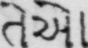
તેઓ
